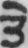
ਤੇ
